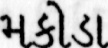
મકોડા
